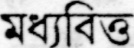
মধ্যবিত্ত
